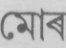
মোৰ
